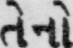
તેનો
